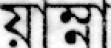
য়াম্না
